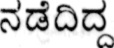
ನಡೆದಿದ್ದ
